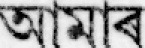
আমাৰ
